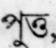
পুত্ত,
